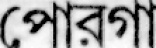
পোরগা
